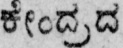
ಕೇಂದ್ರದ
